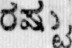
ರಷ್ಟು
